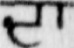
ਦਾ
